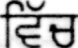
ਵਿਚ
